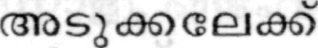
അടുക്കലേക്ക്
